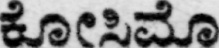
ಕೋಸಿಮೊ
